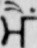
ਮੈਂ
